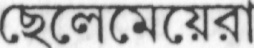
ছেলেমেয়েরা
